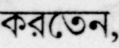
করতেন,
